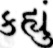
કહ્યું
